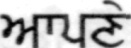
ਆਪਣੇ
